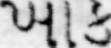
ખાક
